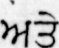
ਅਤੇ
